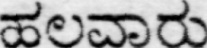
ಹಲವಾರು
